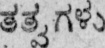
ತತ್ವಗಳು
